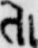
તો
